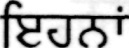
ਇਹਨਾਂ
